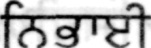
ਨਿਭਾਈ
